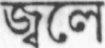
জ্বলে
